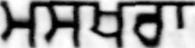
ਮਸਖਰਾ
